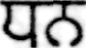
ਧਨ
